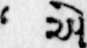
'એ
